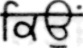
ਕਿਉਂ
